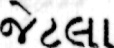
જેટલા
